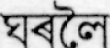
ঘৰলৈ
